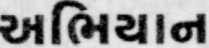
અભિયાન
